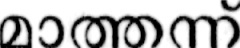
മാത്തന്ന്
